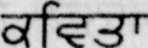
ਕਵਿਤਾ
